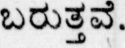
ಬರುತ್ತವೆ.
